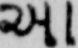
આ
